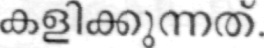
കളിക്കുന്നത്.
